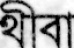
থীবা
